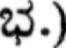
ಭ.)
